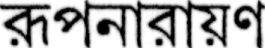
রূপনারায়ণ
